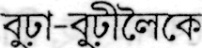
বুঢ়া-বুঢ়ীলৈকে
